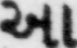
આ
